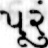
પૂરું
